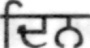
ਦਿਨ
